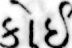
કોઇ
